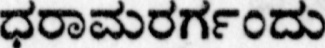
ಧರಾಮರರ್ಗಂದು
